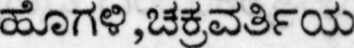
ಹೊಗಳಿ,ಚಕ್ರವರ್ತಿಯ
